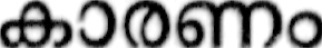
കാരണം
